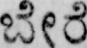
ಬೇರೆ
